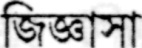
জিজ্ঞাসা
